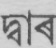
দ্বাৰ
